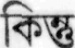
কিন্তু
